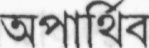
অপার্থিব
